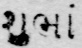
શુભાં
